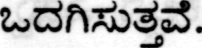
ಒದಗಿಸುತ್ತವೆ.
